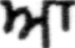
ਆ
